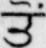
ਤੋਂ
